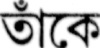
তাঁকে
